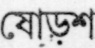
ষোড়শ
